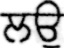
ਲਉ
